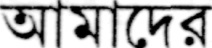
আমাদের
